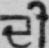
ਦੀ
